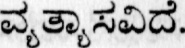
ವ್ಯತ್ಯಾಸವಿದೆ.
